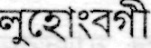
লুহোংবগী
